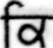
ਕਿ
